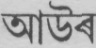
আউৰ
